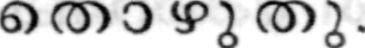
തൊഴുതു.
